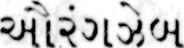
ઔરંગઝેબ
